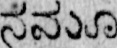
ನಮೂ
